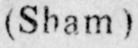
(Sham)
